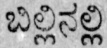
ಬಿಲ್ಲಿನಲ್ಲಿ
